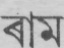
ৰাম
